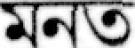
মনত
